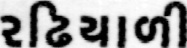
રઢિયાળી
